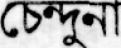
চেন্দুনা
